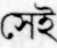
সেই
